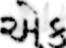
એક
